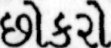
છોકરો
